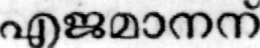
എജമാനന്
